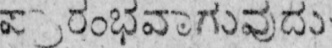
ಪ್ರಾರಂಭವಾಗುವುದು
